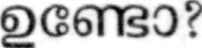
ഉണ്ടോ?
